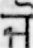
ਜੋ
